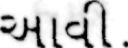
આવી.
